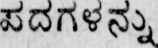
ಪದಗಳನ್ನು
